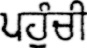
ਪਹੁੰਚੀ
